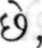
છે,
